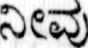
ನೀವು
